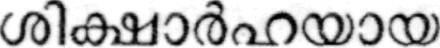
ശിക്ഷാര്‍ഹയായ
